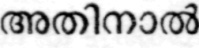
അതിനാല്‍
